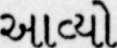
આવ્યો
